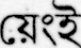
য়েংই
